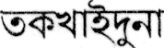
তকখাইদুনা
